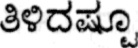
ತಿಳಿದಷ್ಟೂ
